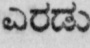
ಎರಡು
